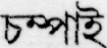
চম্পাই
